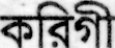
করিগী
